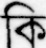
কি
